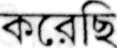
করেছি
